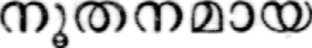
നൂതനമായ
